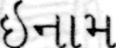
ઇનામ
